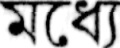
মধ্যে
